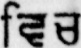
ਵਿਚ
